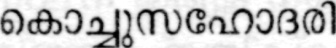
കൊച്ചുസഹോദരി
